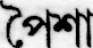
পৈশা
